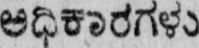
ಅಧಿಕಾರಗಳು
